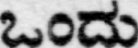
ಒ೦ದು
